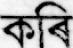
কৰি
